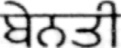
ਬੇਨਤੀ
